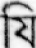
যি
